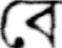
বে
